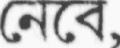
নেবে,
